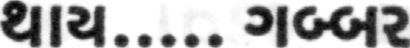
થાય.......ગબ્બર
